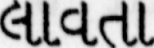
લાવતા
